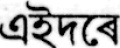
এইদৰে
